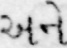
અને
